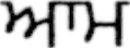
ਆਮ
